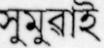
সুমুৱাই
